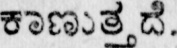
ಕಾಣುತ್ತದೆ.
